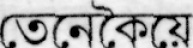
তেনেকৈয়ে
